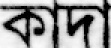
কাদা
